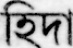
হিদা
